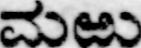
ಮಱು
